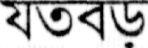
যতবড়
